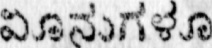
ಮೀನುಗಳೂ
